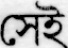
সেই
